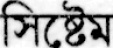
সিষ্টেম
